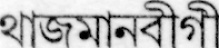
থাজমানবীগী
